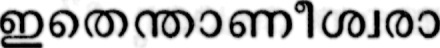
ഇതെന്താണീശ്വരാ
